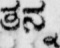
ತನ್ನ
